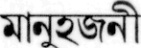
মানুহজনী
